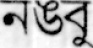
নঙবু
